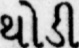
થોડી
